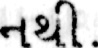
નથી.
